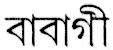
বাবাগী
